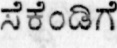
ಸೆಕೆಂಡಿಗೆ
